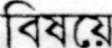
বিষয়ে
